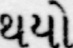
થયો
